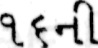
૧૬ની
